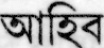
আহিব
